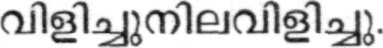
വിളിച്ചുനിലവിളിച്ചു.
